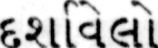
દર્શાવેલો
